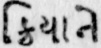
ક્રિયાને
